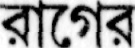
রাগের
